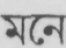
মনে
